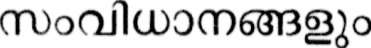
സംവിധാനങ്ങളും
